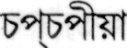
চপ্‌চপীয়া
